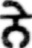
ਨੇ
